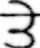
ਤੇ
